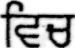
ਵਿਚ
